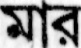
মার
